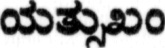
ಯತ್ಸುಖ೦
